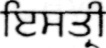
ਇਸਤ੍ਰੀ
